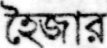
হৈজার
